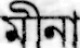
মীনা
